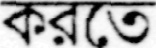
করতে
